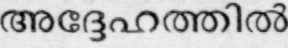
അദ്ദേഹത്തില്‍
